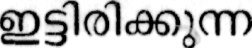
ഇട്ടിരിക്കുന്ന
